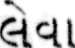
લેવા
